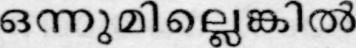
ഒന്നുമില്ലെങ്കില്‍
